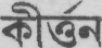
কীৰ্ত্তন
